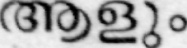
ആളും
